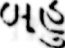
બહુ
